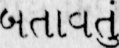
બતાવતું
